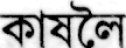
কাষলৈ
